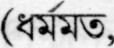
(ধর্মমত,
